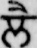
ਲੈ
